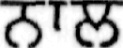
ਨਾਲ
